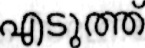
എടുത്ത്
